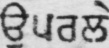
ਉਪਰਲੇ
